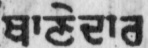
ਥਾਣੇਦਾਰ
